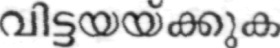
വിട്ടയയ്ക്കുക
